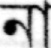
না
